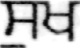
ਸੁਖ
